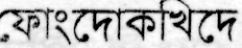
ফোংদোকখিদে
